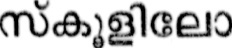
സ്കൂളിലോ
